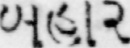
બહાર
